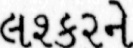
લશ્કરને
